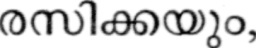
രസിക്കയും,
